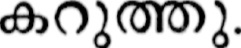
കറുത്തു.
